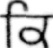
ਕਿ
